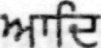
ਆਦਿ
